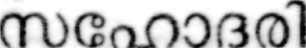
സഹോദരി
